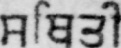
ਸਥਿਤੀ
